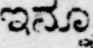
ಇನ್ನೂ
